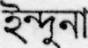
ইন্দুনা
